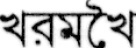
খরমখৈ
